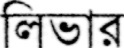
লিভার
